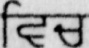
ਵਿਚ
